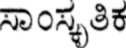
ಸಾಂಸ್ಕೃತಿಕ
